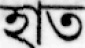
হাত
